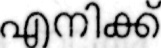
എനിക്ക്
